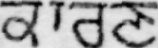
ਕਾਰਣ
